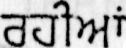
ਰਹੀਆਂ
